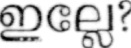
ഇല്ലേ?
